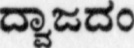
ದ್ವಾಜದಂ
